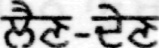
ਲੈਣ-ਦੇਣ
